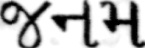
જનમ
